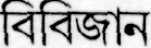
বিবিজান
